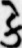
કે
